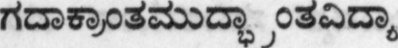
ಗದಾಕ್ರಾಂತಮುದ್ಭ್ರಾಂತವಿದ್ಯಾ
